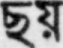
ছয়
